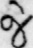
જે
